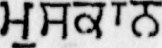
ਮੁਸਕਾਨ
